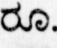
ರೂ.
